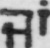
ਜਾਂ
